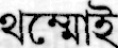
থম্মোই
